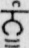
ਨੂੰ
